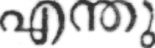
എന്തു
